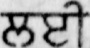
ਲਈ
